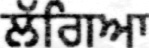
ਲੱਗਿਆ
